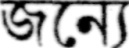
জন্যে
